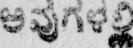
ಅವುಗಳಲ್ಲಿ
